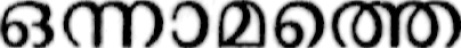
ഒന്നാമത്തെ
